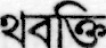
থবক্তি
